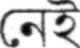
নেই
